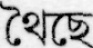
থৈছে
